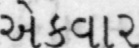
એકવાર
